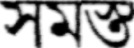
সমস্ত
